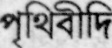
পৃথিবীদি
